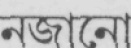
নজানো
